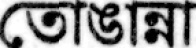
তোঙান্না
